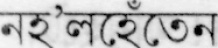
নহ'লহেঁতেন
